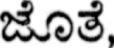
ಜೊತೆ,
